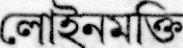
লৌইনমক্তি
